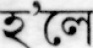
হ'লে
